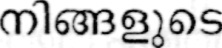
നിങ്ങളുടെ
